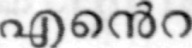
എന്റെ
